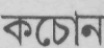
কচোন
